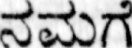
ನಮಗೆ
